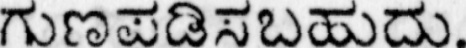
ಗುಣಪಡಿಸಬಹುದು.
